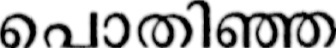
പൊതിഞ്ഞ
